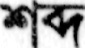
শব্দ
